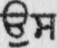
ਉਸ
